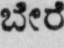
ಬೇರೆ
